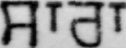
ਸਾਰਾ
